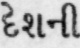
દેશની
